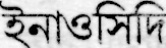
ইনাওসিদি
